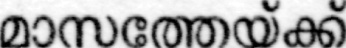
മാസത്തേയ്ക്ക്
